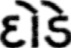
દોડે
